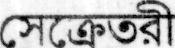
সেক্রেতরী
